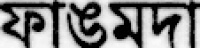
ফাঙমদা
